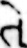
તે
